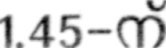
1.45-ന്
